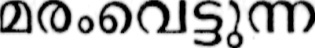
മരംവെട്ടുന്ന
